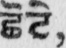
ਛੋਟੇ,
